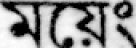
ময়েং
